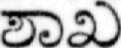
ಶಾಖ
